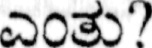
ಎಂತು?
